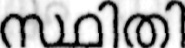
സ്ഥിതി
